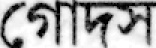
গোদস
